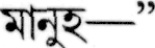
মানুহ-"
